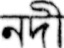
নদী
